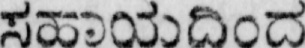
ಸಹಾಯದಿಂದ
